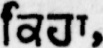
ਕਿਹਾ,
